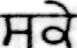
ਸਕੇ
